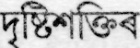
দৃষ্টিশক্তিৰ
